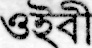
ওইবী
